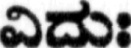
ವಿದುಃ
